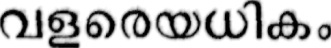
വളരെയധികം
